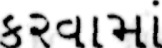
કરવામાં
